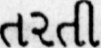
તરતી
